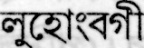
লুহোংবগী
